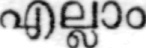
എല്ലാം
